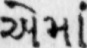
એમાં
